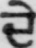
ਦੇ
